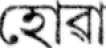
হোৱা
